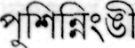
পুশিন্নিংঙী
